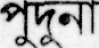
পুদুনা
